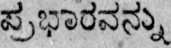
ಪ್ರಭಾರವನ್ನು
